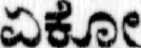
ಏಕೋ
